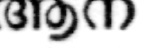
ആന
